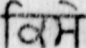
ਕਿਸੇ
